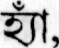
হ্যাঁ,
